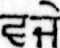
ਵਜੇ
